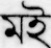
মই
